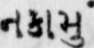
નકામું
